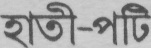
হাতী-পটি
